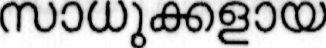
സാധുക്കളായ
